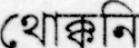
থোক্কনি
